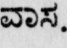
ವಾಸ.
